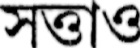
সত্তাও
